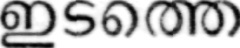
ഇടത്തെ
